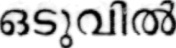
ഒടുവില്‍
